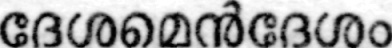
ദേശമെന്‍ദേശം
